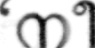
'നീ
